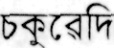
চকুৱেদি
